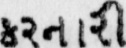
કરનારી
